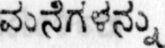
ಮನೆಗಳನ್ನು
